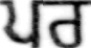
ਪਰ
